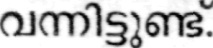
വന്നിട്ടുണ്ട്.
